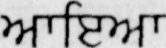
ਆਇਆ
